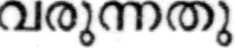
വരുന്നതു
